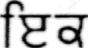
ਇਕ
